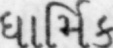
ધાર્મિક
